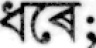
ধৰে;
